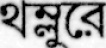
থম্লুরে
